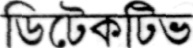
ডিটেকটিভ
